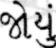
જોયું
